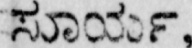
ಸಾರ್ಯ,
